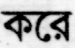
করে
